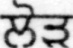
ਲੋੜ
